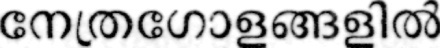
നേത്രഗോളങ്ങളില്‍
